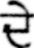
ਦੇ
